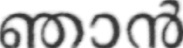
ഞാന്‍
